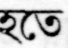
হতে
